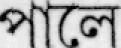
পালে
